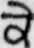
ਕੇ
